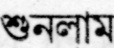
শুনলাম
